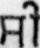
ਸੀ
